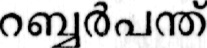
റബ്ബര്‍പന്ത്
